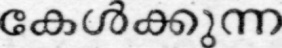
കേള്‍ക്കുന്ന
